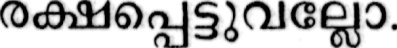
രക്ഷപ്പെട്ടുവല്ലോ.
